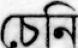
চেনি
